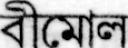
বীমোল
